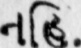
નહિ.
